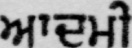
ਆਦਮੀ
